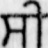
ਸੀ
